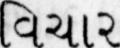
વિચાર
